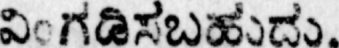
ವಿಂಗಡಿಸಬಹುದು.
